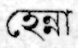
হেন্না
